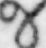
જ
